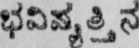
ಭವಿಷ್ಯತ್ತಿನ
